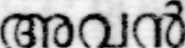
അവന്‍
